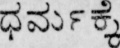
ಧರ್ಮಕ್ಕೆ
